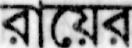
রায়ের
